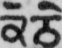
ਕੋਠੇ
